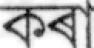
কৰা
